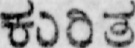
ಕುರಿತ
